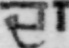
ਦਾ
